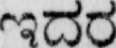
ಇದರ
